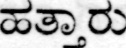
ಹತ್ತಾರು
